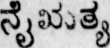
ನೈಋತ್ಯ
